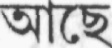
আছে
